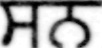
ਸਨ
